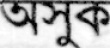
অসুক
